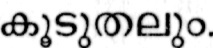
കൂടുതലും.
